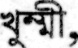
খুম্মী,
